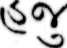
હજુ
